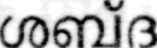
ശബ്ദ
